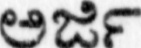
ಅರ್ಜಿ
